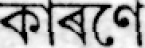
কাৰণে
